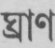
ঘ্ৰাণ
